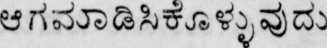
ಆಗಮಾಡಿಸಿಕೊಳ್ಳುವುದು
